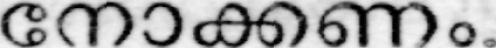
നോക്കണം.
